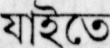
যাইতে
